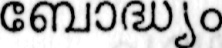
ബോദ്ധ്യം
